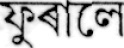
ফুৰালে
